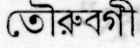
তৌরুবগী
